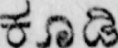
ಕೂಡಿ
